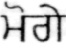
ਮੋਗੇ
